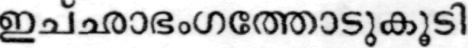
ഇച്ഛാഭംഗത്തോടുകൂടി
